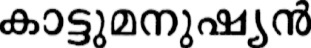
കാട്ടുമനുഷ്യന്‍
